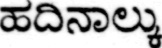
ಹದಿನಾಲ್ಕು
